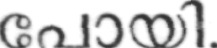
പോയി.
